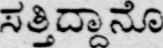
ಸತ್ತಿದ್ದಾನೊ
